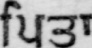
ਪਿਤਾ
